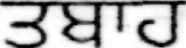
ਤਬਾਹ
